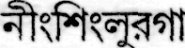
নীংশিংলুরগা
